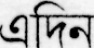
এদিন
